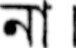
না।
